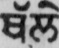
ਥੱਲੇ
